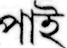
পাই
